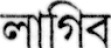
লাগিব
